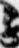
કે
